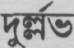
দুৰ্ল্লভ
